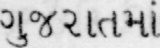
ગુજરાતમાં
